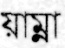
য়াম্না
